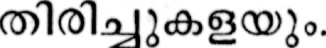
തിരിച്ചുകളയും.
